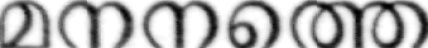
മനനത്തെ
